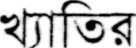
খ্যাতির
